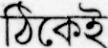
ঠিকেই
